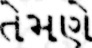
તેમણે
